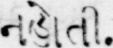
નહોતી.
